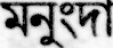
মনুংদা
